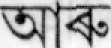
আৰু
